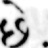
છે.
